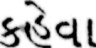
કહેવા
